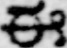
ಈ
